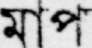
মাপ
